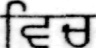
ਵਿਚ
